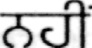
ਨਹੀਂ
